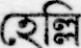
হেল্লি
